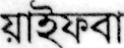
য়াইফবা
